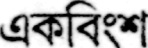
একবিংশ
